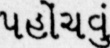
પહોંચવું
